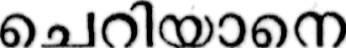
ചെറിയാനെ
